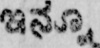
ಇನ್ನೂ
